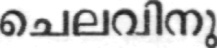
ചെലവിനു
